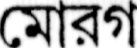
মোরগ
